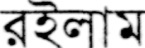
রইলাম
